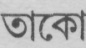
তাকো
